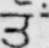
ਤੋਂ
